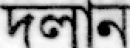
দলান
